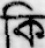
কি
